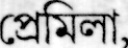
প্রেমিলা,
